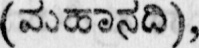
(ಮಹಾನದಿ),
